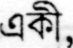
একী,
